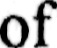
of
